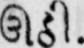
ઊઠી.
